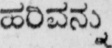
ಹರಿವನ್ನು
